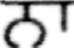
ਨਾ
